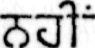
ਨਹੀਂ
